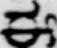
ಈ
